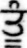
ਤੂੰ
